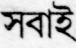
সবাই
